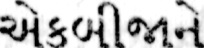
એકબીજાને
